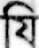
যি
